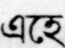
এহে
